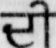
ਦੀ
